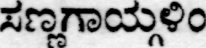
ಸಣ್ಣಗಾಯ್ಗಳಿಂ
